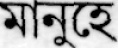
মানুহে
